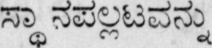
ಸ್ಥಾನಪಲ್ಲಟವನ್ನು
